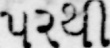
પરથી
